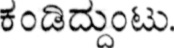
ಕಂಡಿದ್ದುಂಟು.
